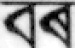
বৰ
